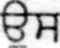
ਉਸ
